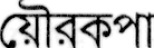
য়ৌরকপা
